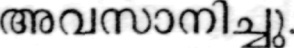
അവസാനിച്ചു.
